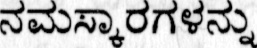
ನಮಸ್ಕಾರಗಳನ್ನು
